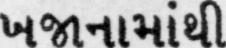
ખજાનામાંથી
